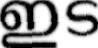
ഇട
